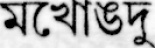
মখোঙদু
